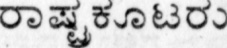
ರಾಷ್ಟ್ರಕೂಟರು
